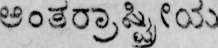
ಅಂತರ್ರಾಷ್ಟ್ರೀಯ
